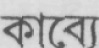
কাব্যে
